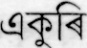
একুৰি
